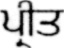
ਪ੍ਰੀਤ
